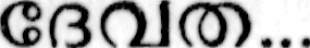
ദേവത...
